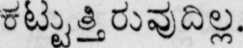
ಕಟ್ಟುತ್ತಿರುವುದಿಲ್ಲ.
